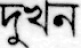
দুখন
